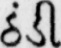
ઠંડી
